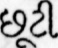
છૂટી
